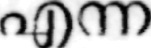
എന്ന
